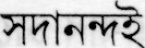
সদানন্দই
